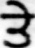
ਤੇ
